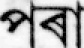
পৰা
